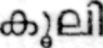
കൂലി
